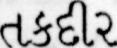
તકદીર
